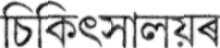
চিকিৎসালয়ৰ
